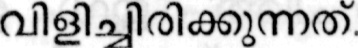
വിളിച്ചിരിക്കുന്നത്.
